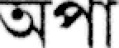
অপা
